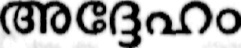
അദ്ദേഹം
